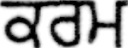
ਕਰਮ
